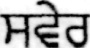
ਸਵੇਰ
